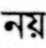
নয়
